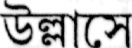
উল্লাসে
